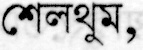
শেলথুম,
